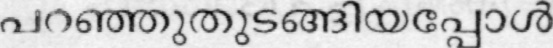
പറഞ്ഞുതുടങ്ങിയപ്പോള്‍
